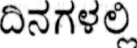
ದಿನಗಳಲ್ಲಿ
